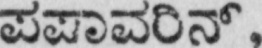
ಪಪಾವರಿನ್,
